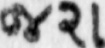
જરા
